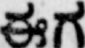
ಈಗ
